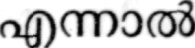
എന്നാല്‍
